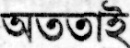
অততাই
